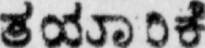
ತಯಾರಿಕೆ
